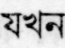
যখন
